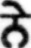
ਨੇ
